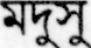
মদুসু
